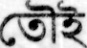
তৌই
